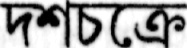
দশচক্রে
